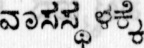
ವಾಸಸ್ಥಳಕ್ಕೆ
